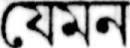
যেমন
